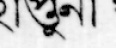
হাপ্তুনা
